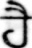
ਹੈ
